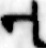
ન
